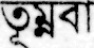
তূম্নবা
